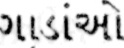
ગાડાંઓ
